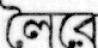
লৈরে
